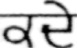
ਕਦੇ
